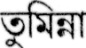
তুমিন্না
